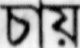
চায়
